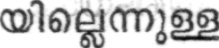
യില്ലെന്നുള്ള
